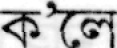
ক'লে
